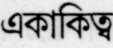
একাকিত্ব
